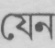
যেন
